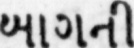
બાગની
